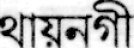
থায়নগী
